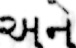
અને
